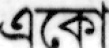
একো
